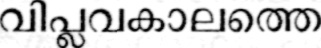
വിപ്ലവകാലത്തെ
